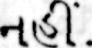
નહીં.
